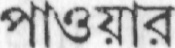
পাওয়ার
